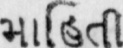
માહિતી
